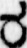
ರ
